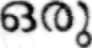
ഒരു
